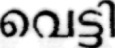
വെട്ടി
